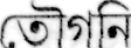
তৌগনি
